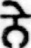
ਨੇ
